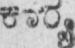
ಕಾರ್‍ಯ
